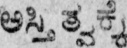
ಅಸ್ತಿತ್ವಕ್ಕೆ
